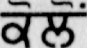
ਕੋਲੋਂ
